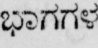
ಭಾಗಗಳ
